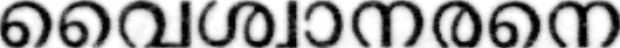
വൈശ്വാനരനെ
